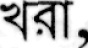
খরা,
